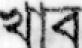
খাব
